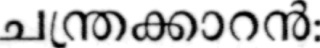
ചന്ത്രക്കാറന്‍:
